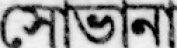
সোভানা
